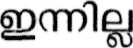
ഇന്നില്ല
